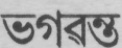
ভগৱন্ত
